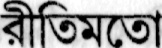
রীতিমতো
